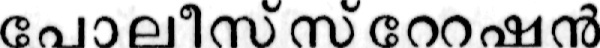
പോലീസ്സ്റ്റേഷന്‍
